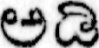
ಅಡಿ
